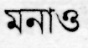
মনাও
